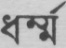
ধৰ্ম্ম
